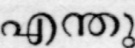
എന്തു
